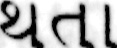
થતા
